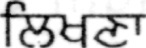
ਲਿਖਣਾ
